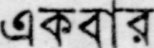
একবার
